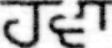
ਹਵਾ
